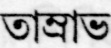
তাম্রাভ
